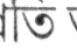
প্ৰতি
